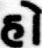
હો
